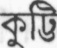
কুট্টি
